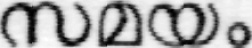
സമയം
